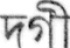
দগী
